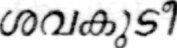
ശവകുടീ
